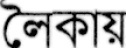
লৈকায়
